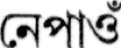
নেপাওঁ
